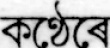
কণ্ঠেৰে
